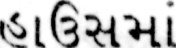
હાઉસમાં
